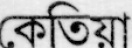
কেতিয়া
